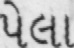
પેલા
